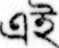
এই
